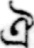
ঐ
